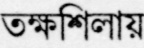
তক্ষশিলায়
